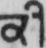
ਕੀ
